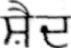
ਸ਼ੈਦ
